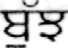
ਬੁੱਝ
